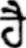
ਹੈ
